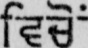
ਵਿਚੋਂ
